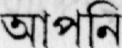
আপনি
